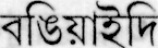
বঙিয়াইদি
